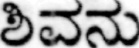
ಶಿವನು
